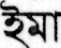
ইমা
